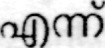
എന്ന്
